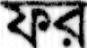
ফর
